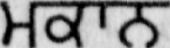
ਮਕਾਨ
